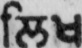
ਲਿਖ
